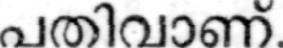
പതിവാണ്.
